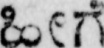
ಹೀಗೆ
